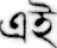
এই
